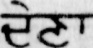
ਦੇਣਾ
